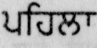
ਪਹਿਲਾ
